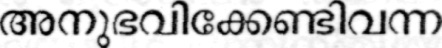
അനുഭവിക്കേണ്ടിവന്ന
